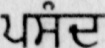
ਪਸੰਦ
